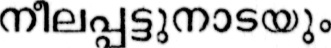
നീലപ്പട്ടുനാടയും
